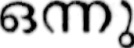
ഒന്നു
